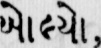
બોલ્યો,
